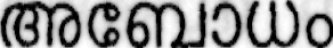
അബോധം
